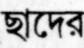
ছাদের
